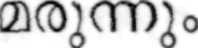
മരുന്നും
